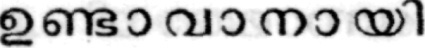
ഉണ്ടാവാനായി
